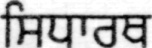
ਸਿਧਾਰਥ
